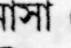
নাসা
